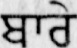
ਬਾਰੇ
